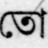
তো
